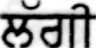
ਲੱਗੀ
